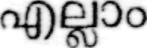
എല്ലാം
